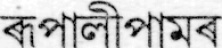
ৰূপালীপামৰ
